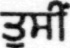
ਤੁਸੀਂ
